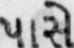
પાસે
